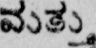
ಮತ್ತು
